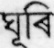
ঘূৰি
